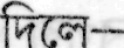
দিলে-
